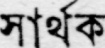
সার্থক
